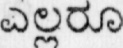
ಎಲ್ಲರೂ
